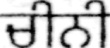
ਚੀਨੀ
